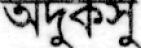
অদুকসু
